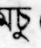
মচু
